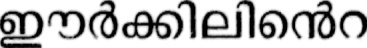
ഈര്‍ക്കിലിന്റെ
